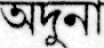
অদুনা
